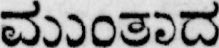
ಮುಂತಾದ
